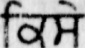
ਕਿਸੇ
